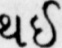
થઈ
